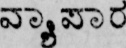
ವ್ಯಾಪಾರ
